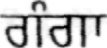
ਗੰਗਾ
